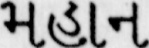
મહાન
